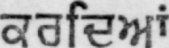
ਕਰਦਿਆਂ
